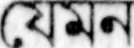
যেমন
